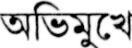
অভিমুখে
